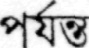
পর্যন্ত
